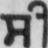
ਸੀ
